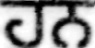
ਹਨ
